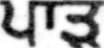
ਪਾੜ
